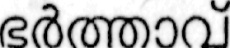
ഭര്‍ത്താവ്
